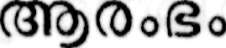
ആരംഭം
